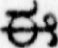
ಈ
